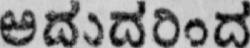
ಆದುದರಿಂದ
